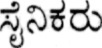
ಸೈನಿಕರು
